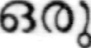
ഒരു
